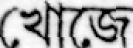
খোজে
